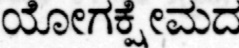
ಯೋಗಕ್ಷೇಮದ
